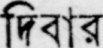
দিবার
